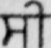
ਸੀ
